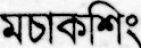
মচাকশিং
